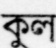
কুল
